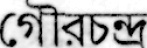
গৌরচন্দ্র
